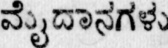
ಮೈದಾನಗಳು
